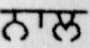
ਨਾਲ
